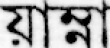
য়াম্না
